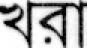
খরা
